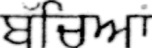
ਬੱਚਿਆਂ
